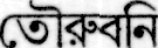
তৌরুবনি
